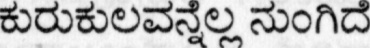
ಕುರುಕುಲವನ್ನೆಲ್ಲನುಂಗಿದೆ
